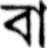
বা
